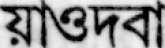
য়াওদবা
